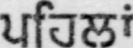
ਪਹਿਲਾਂ
